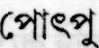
পোৎপু
